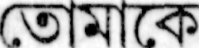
তোমাকে
